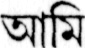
আমি
